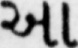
આ
